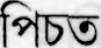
পিচত
